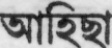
আহিছা
